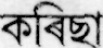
কৰিছা
